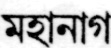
মহানাগ
